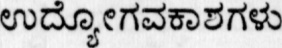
ಉದ್ಯೋಗಾವಕಾಶಗಳು
